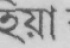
হিয়া
